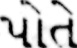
પોતે
